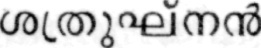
ശത്രുഘ്നന്‍
